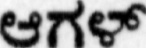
ಆಗಳ್
